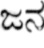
ಜನ
